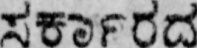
ಸರ್ಕಾರದ
